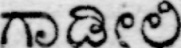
ಗಾಡೀಲಿ
